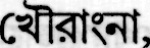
খৌরাংনা,
